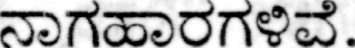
ನಾಗಹಾರಗಳಿವೆ.
